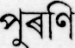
পুৰণি
